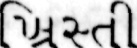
ખ્રિસ્તી
